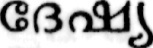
ദേഷ്യ
